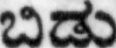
ಬಿಡು
